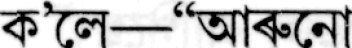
ক'লে-"আৰুনো
